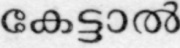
കേട്ടാല്‍
